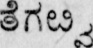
ತೆಗೞ್ವ
